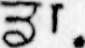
ਡਾ.
